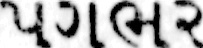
પગભર
